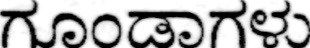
ಗೂಂಡಾಗಳು
